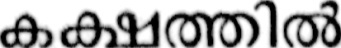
കക്ഷത്തില്‍
